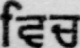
ਵਿਚ
